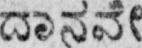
ದಾನವೇ
